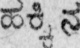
ಹಕ್ಕಿನ
